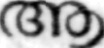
ആ
